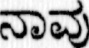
ನಾವು
